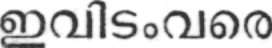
ഇവിടംവരെ
